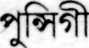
পুন্সিগী
